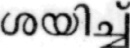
ശയിച്ച്
